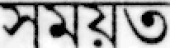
সময়ত
